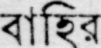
বাহির
